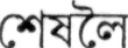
শেষলৈ
